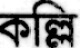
কল্লি
